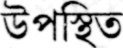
উপস্থিত
